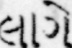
લાગે
